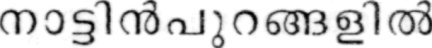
നാട്ടിന്‍പുറങ്ങളില്‍
